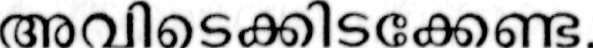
അവിടെക്കിടക്കേണ്ട.
